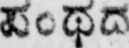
ಪಂಥದ
